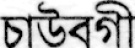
চাউবগী
